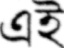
এই
